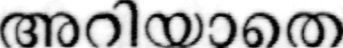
അറിയാതെ
